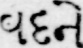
વદને
